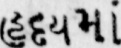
હ્રદયમાં
